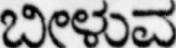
ಬೀಳುವ
